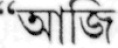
"আজি
